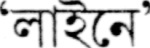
‘লাইনে’
